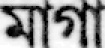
মাগা
